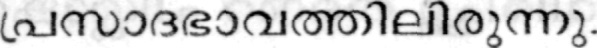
പ്രസാദഭാവത്തിലിരുന്നു.
